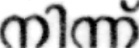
നിന്ന്
